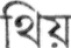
থিয়
